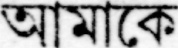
আমাকে
